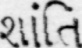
શાંતિ
